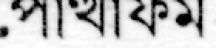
পোত্থাফম
